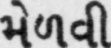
મેળવી
